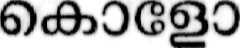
കൊളോ
